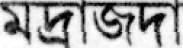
মদ্রাজদা
